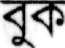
বুক
